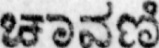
ಚಾವಣಿ
